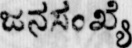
ಜನಸಂಖ್ಯೆ
